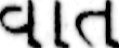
વાત
